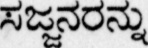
ಸಜ್ಜನರನ್ನು
